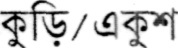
কুড়ি/একুশ
